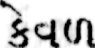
કેવળ
